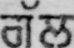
ਗੱਲ
